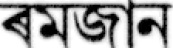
ৰমজান
